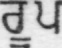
ਰੂਪ
